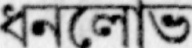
ধনলোভ
